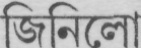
জিনিলো
